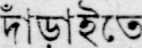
দাঁড়াইতে
